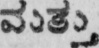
ಮತ್ತು
